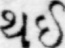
થઈ
